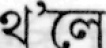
থ'লে
